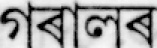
গৰালৰ
